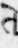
તે
